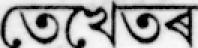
তেখেতৰ
